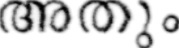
അതും
